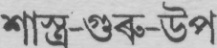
শাস্ত্ৰ-গুৰু-উপ
